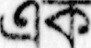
এক
